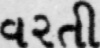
વરતી
